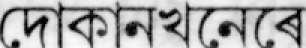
দোকানখনেৰে
